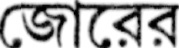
জোরের
